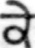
ਕੇ
